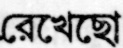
রেখেছো
